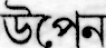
উপেন
